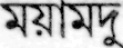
ময়ামদু
